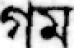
গম
